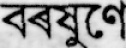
বৰষুণে
